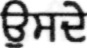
ਉਸਦੇ
